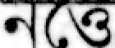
নত্তে
